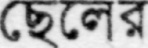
ছেলের
